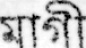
মাগী
